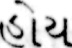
હોય
